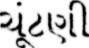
ચૂંટણી
